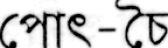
পোৎ-চৈ
